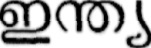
ഇന്ത്യ
